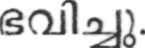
ഭവിച്ചു.
